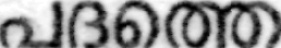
പദത്തെ
